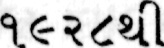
૧૯૨૮થી
